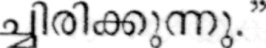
ച്ചിരിക്കുന്നു."
